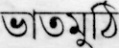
ভাতমুঠি
